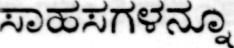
ಸಾಹಸಗಳನ್ನೂ
